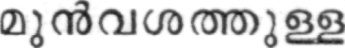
മുന്‍വശത്തുള്ള
